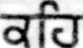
ਕਹਿ
